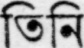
তিনি
